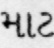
માટ
